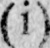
(i)
